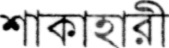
শাকাহারী
